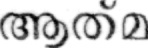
ആത്മ
